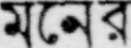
মনের
